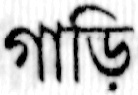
গাড়ি
